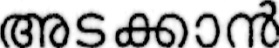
അടക്കാന്‍
